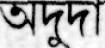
অদুদা
